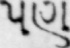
પણ
